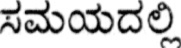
ಸಮಯದಲ್ಲಿ
